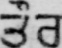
ਤੌਰ
